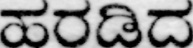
ಹರಡಿದ
